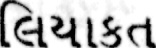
લિયાકત
